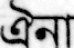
ঐনা
